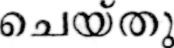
ചെയ്തു
